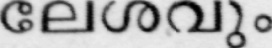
ലേശവും
